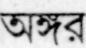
অঙ্গর
